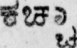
ಕಚ್ಚಾ
